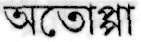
অতোপ্পা
